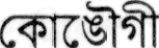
কোঙৌগী
